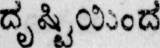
ದೃಷ್ಟಿಯಿಂದ
